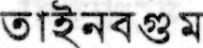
তাইনবগুম
